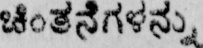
ಚಿಂತನೆಗಳನ್ನು
